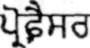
ਪ੍ਰੋਫ਼ੈਸਰ
